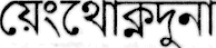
য়েংথোক্নদুনা
